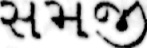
સમજી
